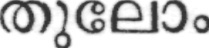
തുലോം
